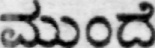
ಮುಂದೆ
